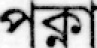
পক্না
